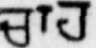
ਚਾਹ
